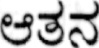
ಆತನ
